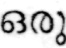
ഒരു
